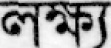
লক্ষ্য
